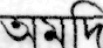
অমদি
